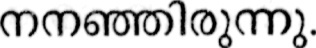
നനഞ്ഞിരുന്നു.
